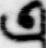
এ
